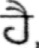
ਹੈ,
